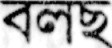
বলছ
